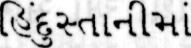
હિંદુસ્તાનીમાં
